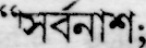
"সর্বনাশ;
